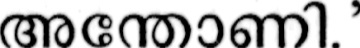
അന്തോണി.’
